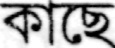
কাছে
